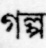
গল্প
